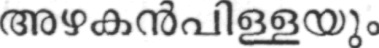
അഴകന്‍പിള്ളയും
